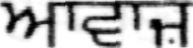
ਆਵਾਜ਼
